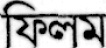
ফিলম
